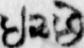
ઇચ્છે
